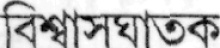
বিশ্বাসঘাতক
